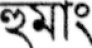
হুমাং
